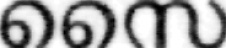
സൈ
